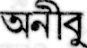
অনীবু
